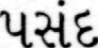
પસંદ
